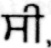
ਸੀ,
